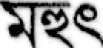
মহুৎ
